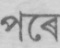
পৰে
